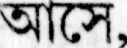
আসে,
